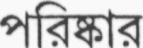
পরিষ্কার
